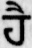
ਹੈ
